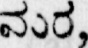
ಮರ,
